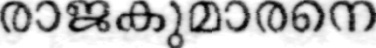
രാജകുമാരനെ
